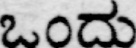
ಒ೦ದು
